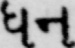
ધન
